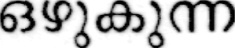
ഒഴുകുന്ന
